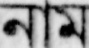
নাম
